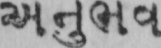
અનુભવ
